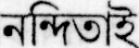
নন্দিতাই
